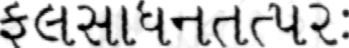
ફલસાધનતત્પરઃ
